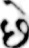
છે
